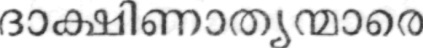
ദാക്ഷിണാത്യന്മാരെ
